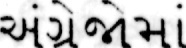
અંગ્રેજોમાં
